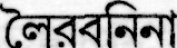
লৈরবনিনা
